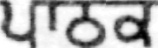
ਪਾਠਕ
